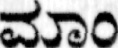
ಮಾಂ
